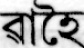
ৱাহৈ
